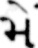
મેં
